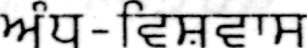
ਅੰਧ-ਵਿਸ਼ਵਾਸ
